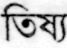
তিষ্য
